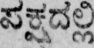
ಪಕ್ಷದಲ್ಲಿ
